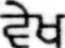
ਵੇਖ
